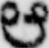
ಆ
